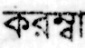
করম্বা
